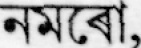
নমৰো,
